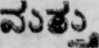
ಮತ್ತು
